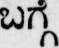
ಬಗ್ಗೆ
